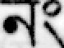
নং
